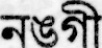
নঙগী
